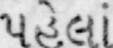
પહેલાં
